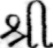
શ્રી
